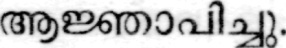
ആജ്ഞാപിച്ചു.
